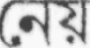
নেয়
